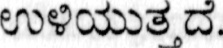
ಉಳಿಯುತ್ತದೆ.
